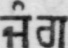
ਜੰਗ
